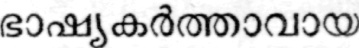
ഭാഷ്യകര്‍ത്താവായ
